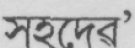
সহদেৱ'
